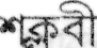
শক্লবী
